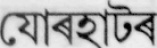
যোৰহাটৰ
